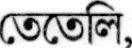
তেতেলি,
